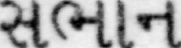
સભાન
